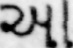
આ
